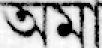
অমা
